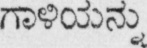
ಗಾಳಿಯನ್ನು
